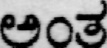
ಅಂತ
